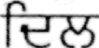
ਦਿਲ
